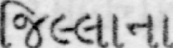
જિલ્લાના
